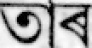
তাৰ
